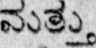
ಮತ್ತು
